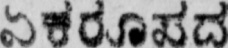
ಏಕರೂಪದ
